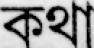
কথা
